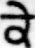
ਕੇ
